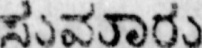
ಸುಮಾರು
